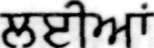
ਲਈਆਂ
